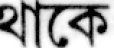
থাকে
